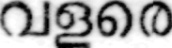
വളരെ
